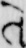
તે
